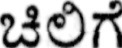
ಚಿಲಿಗೆ
